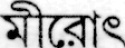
মীরোৎ
